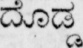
ದೊಡ್ಡ
